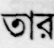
তার
